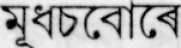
মূধচবোৰে
